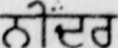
ਨੀਂਦਰ
